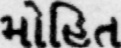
મોહિત
